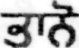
ਭਾਨੋ
